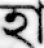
হা
